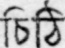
চিঠি
